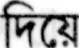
দিয়ে
